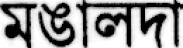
মঙালদা
